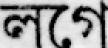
লগে
